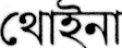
থোইনা
